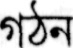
গঠন
